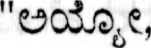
“ಅಯ್ಯೋ,
